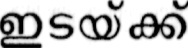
ഇടയ്ക്ക്
